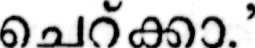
ചെറ്ക്കാ.’
